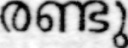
രണ്ടു
